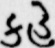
કહે
